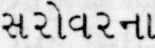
સરોવરના
